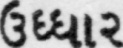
ઉધ્ધાર
